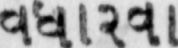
વધારવા
